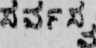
ಸರ್ವಸ್ವ
